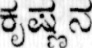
ಕೃಷ್ಣನ
